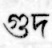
গুদ
